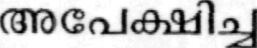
അപേക്ഷിച്ച
